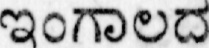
ಇಂಗಾಲದ
